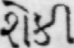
શેકી
